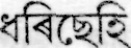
ধৰিছেহি
